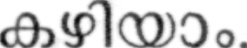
കഴിയാം.
